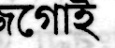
জগোই
